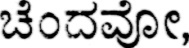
ಚೆಂದವೋ,
